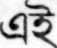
এই
